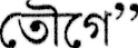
তৌগে”
